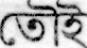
তৌই
